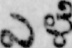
ಎಳೆ
